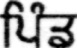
ਪਿੰਡ
